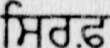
ਸਿਰਫ਼
